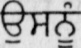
ਉਸਨੂੰ
